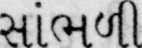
સાંભળી
